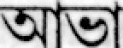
আভা
